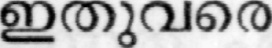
ഇതുവരെ
